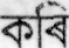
কৰি
